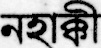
নহাক্কী
